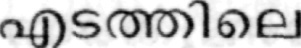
എടത്തിലെ
